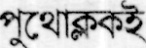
পুথোক্লকই
